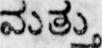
ಮತ್ತು
